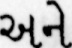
અને
